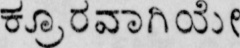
ಕ್ರೂರವಾಗಿಯೇ
